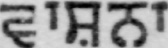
ਵਾਸ਼ਨਾ
